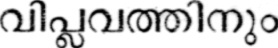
വിപ്ലവത്തിനും
